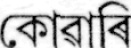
কোৱাৰি
